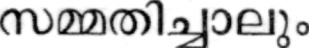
സമ്മതിച്ചാലും
